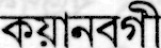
কয়ানবগী
